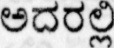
ಅದರಲ್ಲಿ
